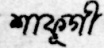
শাফূগী
